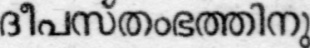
ദീപസ്തംഭത്തിനു
